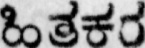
ಹಿತಕರ
